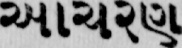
આચરણ
